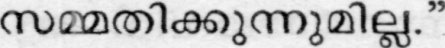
സമ്മതിക്കുന്നുമില്ല.”
